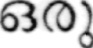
ഒരു
